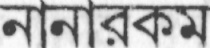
নানারকম
